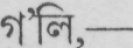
গ'লি,-
